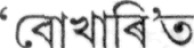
'বোখাৰি'ত
